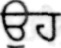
ਉਹ
